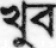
খুব
